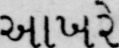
આખરે
